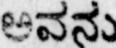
ಅವನು
